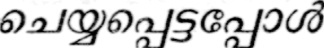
ചെയ്യപ്പെട്ടപ്പോള്‍
